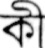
কী
